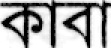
কাবা
